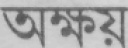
অক্ষয়
